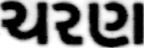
ચરણ
